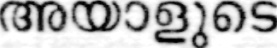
അയാളുടെ
